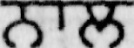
ਨਾਲ
